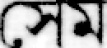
সেম
